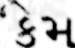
'કેમ
